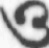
ও
